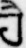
ਹੈ
